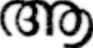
ആ
